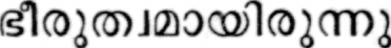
ഭീരുത്വമായിരുന്നു
